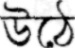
উঠে
